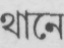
থানে
